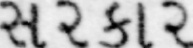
સરકાર
